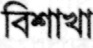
বিশাখা
